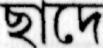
ছাদে
